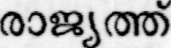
രാജ്യത്ത്
